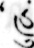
હું
